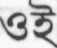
ওই
